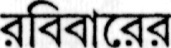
রবিবারের
